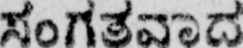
ಸಂಗತವಾದ
